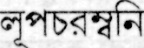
লূপচরম্বনি
